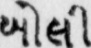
બોલી
